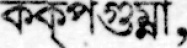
ককপগুম্না,
